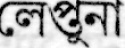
লেপ্তুনা
